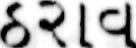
ઠરાવ
